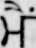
ਮੈਂ
